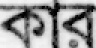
কার
